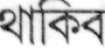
থাকিব
